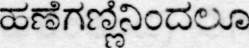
ಹಣೆಗಣ್ಣಿನಿಂದಲೂ
